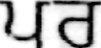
ਪਰ
